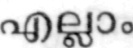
എല്ലാം
